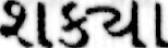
શક્યા
